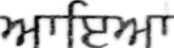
ਆਇਆ
